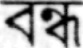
বন্ধ
